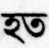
হত
